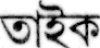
তাইক
